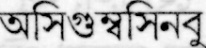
অসিগুম্বসিনবু
